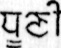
ਧੂਣੀ
